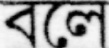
বলে
